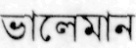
ভালেমান
